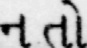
નતો
